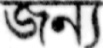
জন্য
